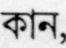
কান,
